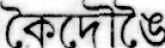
কৈদৌঙৈ
